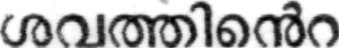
ശവത്തിന്റെ
